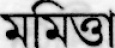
মমিত্তা
